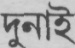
দুনাই
